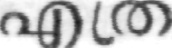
എത്ര
